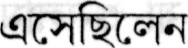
এসেছিলেন
